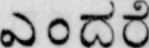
ಎಂದರೆ
